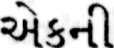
એકની
